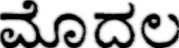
ಮೊದಲ
